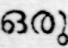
ഒരു
